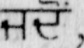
ਜਦੋਂ,
